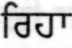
ਰਿਹਾ
